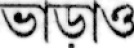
ভাড়াও
